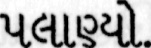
પલાણ્યો.
